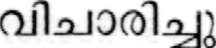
വിചാരിച്ചു
